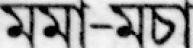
মমা-মচা
